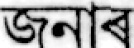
জনাৰ
